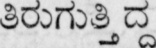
ತಿರುಗುತ್ತಿದ್ದ
